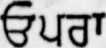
ਓਪਰਾ
